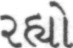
રહ્યો
